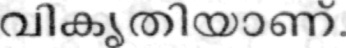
വികൃതിയാണ്.
